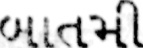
બાતમી
